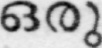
ഒരു
